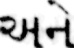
અને
